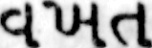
વખત
